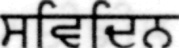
ਸਵਿਦਿਨ
